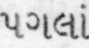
પગલાં
